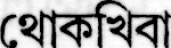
থোকখিবা
